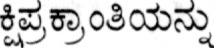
ಕ್ಷಿಪ್ರಕ್ರಾಂತಿಯನ್ನು
